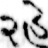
રહે
